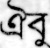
ঐবু
